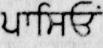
ਪਾਸਿਓਂ
